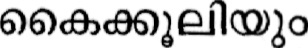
കൈക്കൂലിയും
